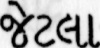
જેટલા
